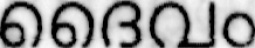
ദൈവം
